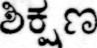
ಶಿಕ್ಷಣ
